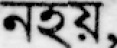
নহয়,
